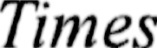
Times
